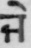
ਜੇ
